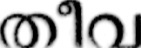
തീവ
